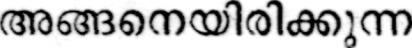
അങ്ങനെയിരിക്കുന്ന
